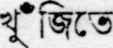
খুঁজিতে
